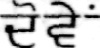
ਦੋਵੇਂ
